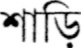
শাড়ি
